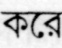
করে
